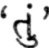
'તું'
